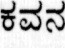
ಕವನ
